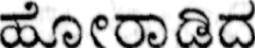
ಹೋರಾಡಿದ
